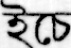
ইচে
